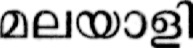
മലയാളി
